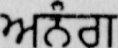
ਅਨੰਗ
